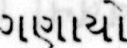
ગણાયો
